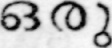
ഒരു
